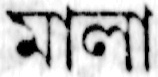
মালা
